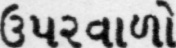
ઉપરવાળો
